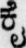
ಕೈ
